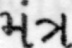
મંત્ર
